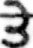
ਤੇ
